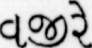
વજીરે
